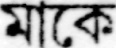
মাকে
